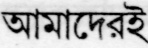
আমাদেরই
